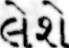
લેશે
